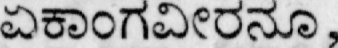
ಏಕಾಂಗವೀರನೂ,
